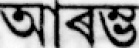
আৰম্ভ
